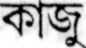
কাজু
